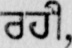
ਰਹੀ,
